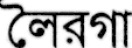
লৈরগা
